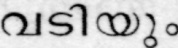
വടിയും
